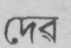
দেৱ
